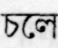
চলে
